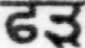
ਫੜ
